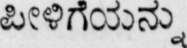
ಪೀಳಿಗೆಯನ್ನು
